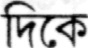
দিকে
